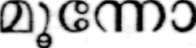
മൂന്നോ
